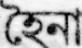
হৈনা
